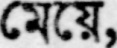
মেয়ে,
